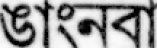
ঙাংনবা
